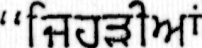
''ਜਿਹੜੀਆਂ
